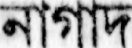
নাগাদ
